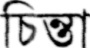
চিন্তা
